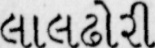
લાલઢોરી
